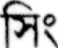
সিং
